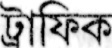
ট্রাফিক
